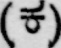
(ಕ)
